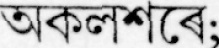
অকলশৰে;
